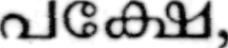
പക്ഷേ,
